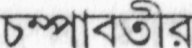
চম্পাবতীর
